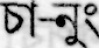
চা-নুং
